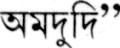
অমদুদি”
